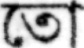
তো
